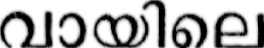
വായിലെ
